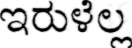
ಇರುಳೆಲ್ಲ
